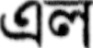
এল
